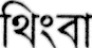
থিংবা
